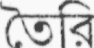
তৈরি
